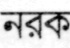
নরক
